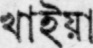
খাইয়া
